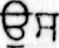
ਉਸ
